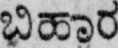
ಬಿಹಾರ
